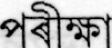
পৰীক্ষা
